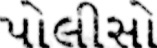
પોલીસો
